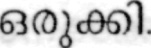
ഒരുക്കി.
